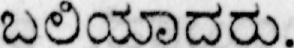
ಬಲಿಯಾದರು.
